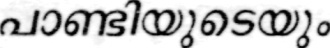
പാണ്ടിയുടെയും
